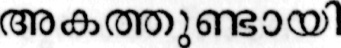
അകത്തുണ്ടായി
